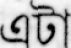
এটা
